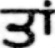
ਤਾਂ
